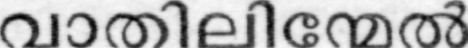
വാതിലിന്മേല്‍
